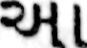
આ
